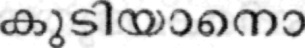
കുടിയാനൊ
